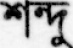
শন্দু
